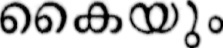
കൈയും
